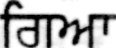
ਗਿਆ
